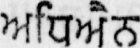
ਅਧਿਐਨ
